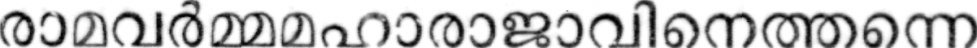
രാമവര്‍മ്മമഹാരാജാവിനെത്തന്നെ
